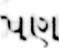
પણ
